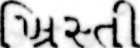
ખ્રિસ્તી
